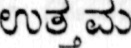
ಉತ್ತಮ
